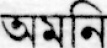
অমনি
